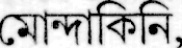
মোন্দাকিনি,
